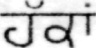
ਹੱਕਾਂ
